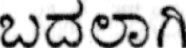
ಬದಲಾಗಿ
